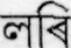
লৰি
